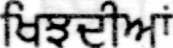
ਖਿਝਦੀਆਂ
